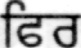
ਫਿਰ
